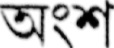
অংশ
